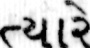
ત્યારે
